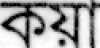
কয়া
